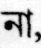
না,
